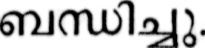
ബന്ധിച്ചു.
